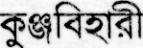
কুঞ্জাবিহারী
